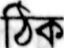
ঠিক
